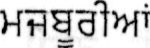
ਮਜਬੂਰੀਆਂ
